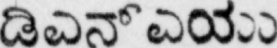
ಡಿಎನ್ಎಯು
